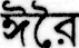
ঈরৈ
